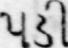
પડી
